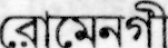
রোমেনগী
